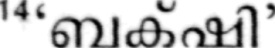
14'ബക്ഷി'
